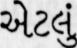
એટલું
